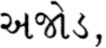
અજોડ,
